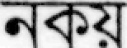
নকয়
